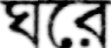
ঘরে
